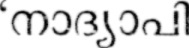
'നാദ്യാപി
